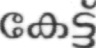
കേട്ട്
